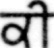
ਕੀ
